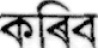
কৰিব
